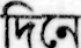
দিনে
